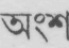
অংশ
